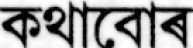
কথাবোৰ
